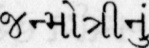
જન્મોત્રીનું
